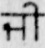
ਜੀ
